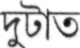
দুটাত
